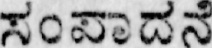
ಸಂಪಾದನೆ
